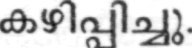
കഴിപ്പിച്ചു.
